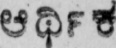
ಆರ್ಥಿಕ
